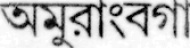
অমুরাংবগা
